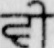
ਵੀ
